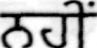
ਨਹੀਂ
